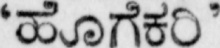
‘ಹೊಗೆಕರಿ’
